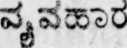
ವ್ಯವಹಾರ
